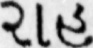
રાહ
